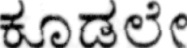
ಕೂಡಲೇ
